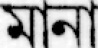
মানা
